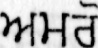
ਅਮਰੋ
